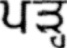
ਪੜ੍ਹ
